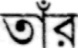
তাঁর
